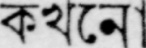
কখনো
